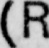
(R
